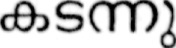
കടന്നു
